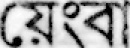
য়েংবা
